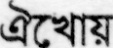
ঐখোয়
